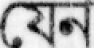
যেন
